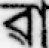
ৱা
